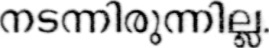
നടന്നിരുന്നില്ല.
